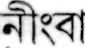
নীংবা
